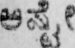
ಅಷ್ಟೇ
